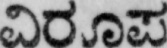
ವಿರೂಪ
